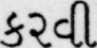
કરવી
